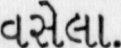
વસેલા.
